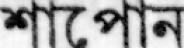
শাপোন
